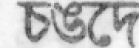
চঙদে
